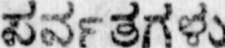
ಪರ್ವತಗಳು
